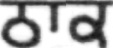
ਠਾਕ
